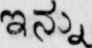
ಇನ್ನು
